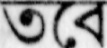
তবে
